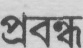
প্ৰবন্ধ
